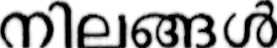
നിലങ്ങള്‍
